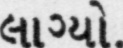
લાગ્યો.
